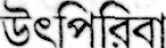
উৎপিরিবা
